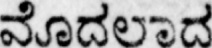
ಮೊದಲಾದ
